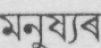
মনুষ্যৰ
